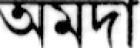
অমদা
